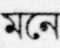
মনে
